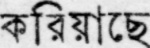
করিয়াছে
